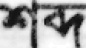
শব্দ
